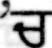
'ਚ
